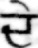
ਦੇ
